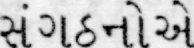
સંગઠનોએ
